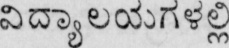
ವಿದ್ಯಾಲಯಗಳಲ್ಲಿ
